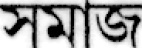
সমাজ
